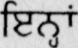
ਇਨ੍ਹਾਂ
